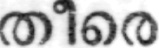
തീരെ
